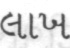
લાખ
